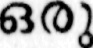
ഒരു
